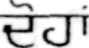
ਦੋਹਾਂ
